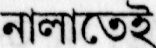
নালাতেই
